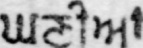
ਘਣੀਆਂ
